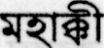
মহাক্কী
